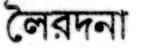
লৈরদনা
